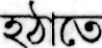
হঠাতে
